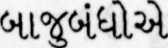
બાજુબંધોએ
